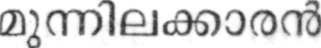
മുന്നിലക്കാരന്‍
